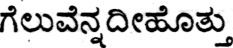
ಗೆಲುವೆನ್ನದೀಹೊತ್ತು
